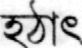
হঠাৎ
